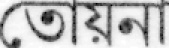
তোয়না
